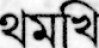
থমখি
